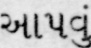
આપવું
